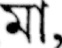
মা,
